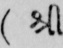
(શ્રી
